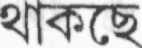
থাকছে
